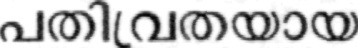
പതിവ്രതയായ
